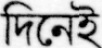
দিনেই
